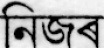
নিজৰ
